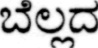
ಬೆಲ್ಲದ
